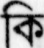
কি
